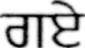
ਗਏ
